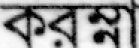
করম্না
